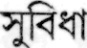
সুবিধা
